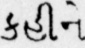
કહીને
